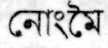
নোংমৈ
